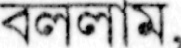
বললাম,
